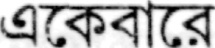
একেবারে
